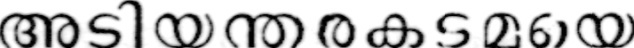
അടിയന്തരകടമയെ
